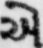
એ
